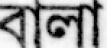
বালা
